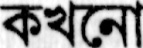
কখনো
